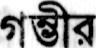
গম্ভীর
